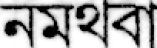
নমথবা
